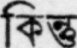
কিন্তু
